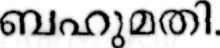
ബഹുമതി.
